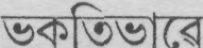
ভকতিভাৱে
